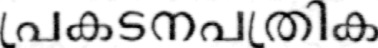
പ്രകടനപത്രിക
